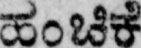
ಹಂಚಿಕೆ
